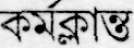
কর্মক্লান্ত
